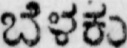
ಬೆಳಕು
